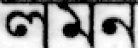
লমন
